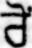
ਰੋਂ
